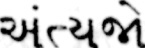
અંત્યજો
